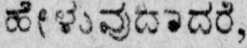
ಹೇಳುವುದಾದರೆ,
